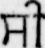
ਸੀ
